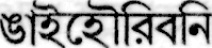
ঙাইহৌরিবনি
